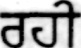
ਰਹੀ
